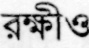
রক্ষীও
